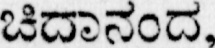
ಚಿದಾನಂದ,
